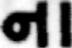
ના
